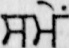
ਸਮੇਂ
